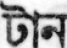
টান
